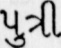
પુત્રી
